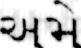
અમે
